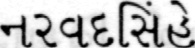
નરવદસિંહે
